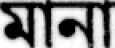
মানা
